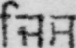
ਜਿਸ
